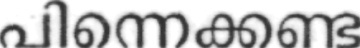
പിന്നെക്കണ്ട
